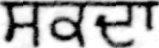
ਸਕਦਾ
